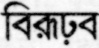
বিরূঢ়ব
